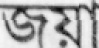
জয়া
